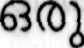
ഒരു
